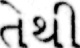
તેથી
